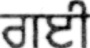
ਗਈ
